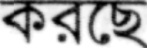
করছে
